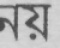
নয়
